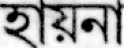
হায়না
